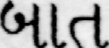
બાત
